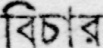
বিচার
